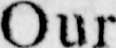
Our
